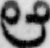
ಆ
